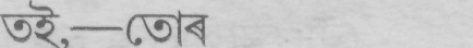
তই,-তোৰ
